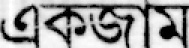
একজাম
